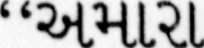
"અમારા
